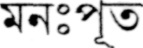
মনঃপূত
